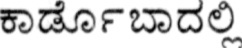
ಕಾರ್ಡೊಬಾದಲ್ಲಿ
